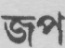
জপ
